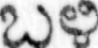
ಬಳಿ
